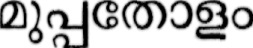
മുപ്പതോളം
